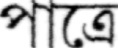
পাত্রে
